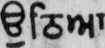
ਉਠਿਆ
